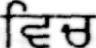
ਵਿਚ
